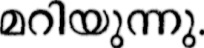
മറിയുന്നു.
